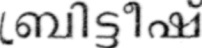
ബ്രിട്ടീഷ്
